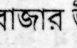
বাজার
